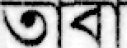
তাবা
